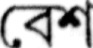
বেশ
